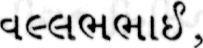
વલ્લભભાઈ,
